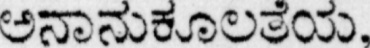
ಅನಾನುಕೂಲತೆಯ,
